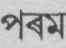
পৰম
